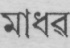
মাধৱ
